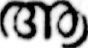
ആ
